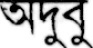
অদুবু
